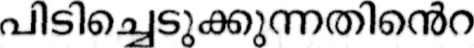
പിടിച്ചെടുക്കുന്നതിന്റെ
